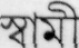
স্বামী
